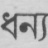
ধন্য
